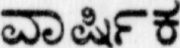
ವಾರ್ಷಿಕ
